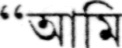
“আমি
